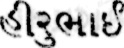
હીરુભાઈ
